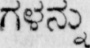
ಗಳನ್ನು
